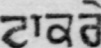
ਟਾਕਰੇ
